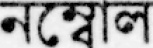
নম্বোল
